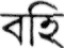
বহি
